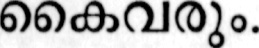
കൈവരും.
